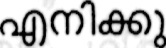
എനിക്കു
